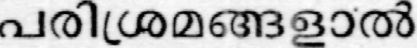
പരിശ്രമങ്ങളാല്‍
